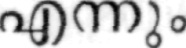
എന്നും
